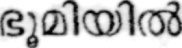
ഭൂമിയില്‍
